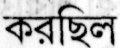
করছিল
